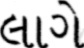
લાગે
